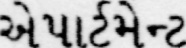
એપાર્ટમેન્ટ
